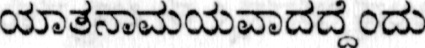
ಯಾತನಾಮಯವಾದದ್ದೆಂದು
